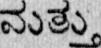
ಮತ್ತು
